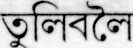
তুলিবলৈ
